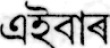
এইবাৰ
